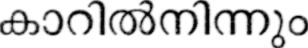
കാറില്‍നിന്നും
